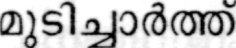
മുടിച്ചാര്‍ത്ത്
